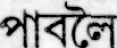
পাবলৈ
